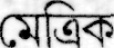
মেত্রিক
